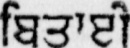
ਬਿਤਾਈ
